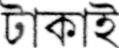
টাকাই
